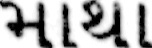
માથા
